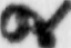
જ
